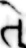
તે
